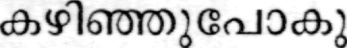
കഴിഞ്ഞുപോകു
